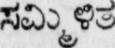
ಸಮ್ಮಿಳಿತ
